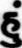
હું
